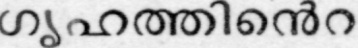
ഗൃഹത്തിന്റെ
